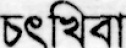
চৎখিবা
